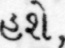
હશે,
